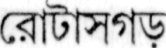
রোটাসগড়
